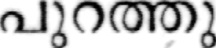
പുറത്തു
